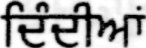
ਦਿੰਦੀਆਂ
